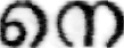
നെ
